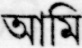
আমি
